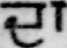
ਦਾ
